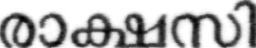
രാക്ഷസി
